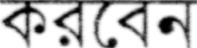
করবেন
